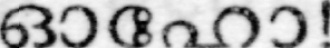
ഓഹോ!
